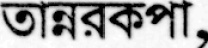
তান্নরকপা,
